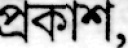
প্রকাশ,
